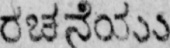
ರಚನೆಯು
